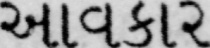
આવકાર
